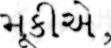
મૂકીએ,
